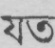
যত
